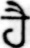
ਹੈ
